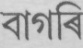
বাগৰি
